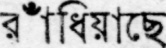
রাঁধিয়াছে
